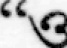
“ও
